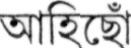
আহিছোঁ
